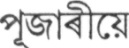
পূজাৰীয়ে
